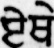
ਏਥੇ
